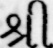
શ્રી
